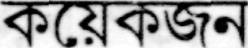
কয়েকজন
